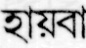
হায়বা
